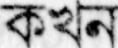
কখন
